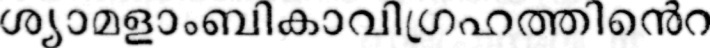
ശ്യാമളാംബികാവിഗ്രഹത്തിന്റെ
